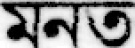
মনত
